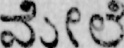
ಮೇಲೆ
